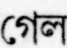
গেল
